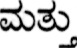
ಮತ್ತು
